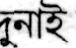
দুনাই
